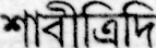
শাবীত্রিদি
